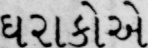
ઘરાકોએ
